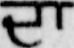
ਦਾ
